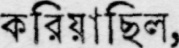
করিয়াছিল,
